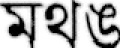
মথঙ
